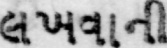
લખવાની
